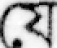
যে
